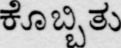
ಕೊಬ್ಬಿತು
